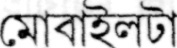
মোবাইলটা
